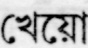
খেয়ো
